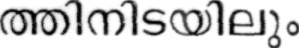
ത്തിനിടയിലും
